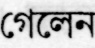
গেলেন
